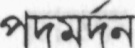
পদমর্দন
